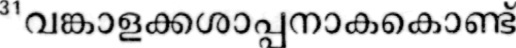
31വങ്കാളക്കശാപ്പനാകകൊണ്ട്
